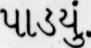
પાડ્યું.
